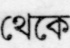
থেকে
